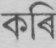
কৰি
